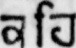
ਕਹਿ
